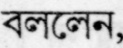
বললেন,
